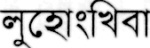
লুহোংখিবা
